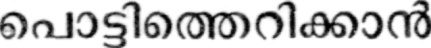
പൊട്ടിത്തെറിക്കാന്‍
